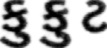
કુકુટ
